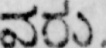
ವರು.
